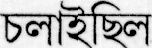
চলাইছিল
